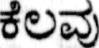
ಕೆಲವು
